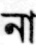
না
